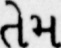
તેમ
